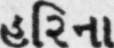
હરિના
